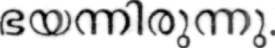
ഭയന്നിരുന്നു.
